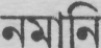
নমানি
